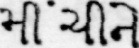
મીંચીને
